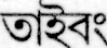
তাইবং
